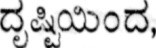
ದೃಷ್ಟಿಯಿಂದ,
